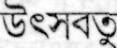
উৎসবতু
